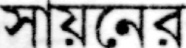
সায়নের
